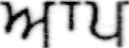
ਆਪ
